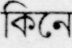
কিনে
